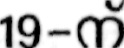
19-ന്
